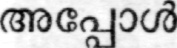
അപ്പോള്‍
